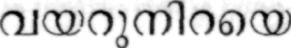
വയറുനിറയെ
